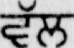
ਵੱਲ
